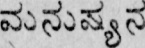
ಮನುಷ್ಯನ
